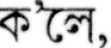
ক'লে,
